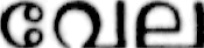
വേല
